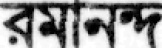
রমানন্দ
